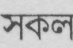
সকল
